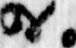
જ.
